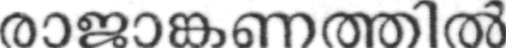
രാജാങ്കണത്തില്‍
